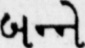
બન્ને
